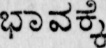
ಭಾವಕ್ಕೆ
